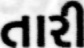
તારી
